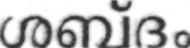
ശബ്ദം
